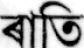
ৰাতি
